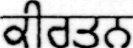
ਕੀਰਤਨ
